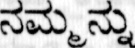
ನಮ್ಮನ್ನು
